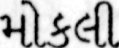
મોકલી
